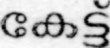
കേട്ട്
